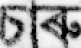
চাৰু
